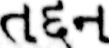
તદ્દન
